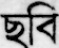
ছবি
